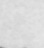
તો
